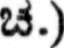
ಚ)
